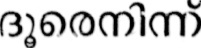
ദൂരെനിന്ന്
